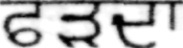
ਫੜਦਾ
